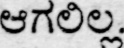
ಆಗಲಿಲ್ಲ.
